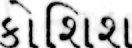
કોશિશ
